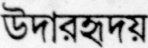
উদারহৃদয়
